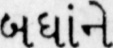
બધાંને
